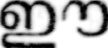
ഈ
